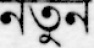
নতুন
